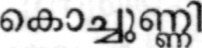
കൊച്ചുണ്ണി
